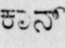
ಕಾನ್
